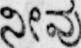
ನೀವು
